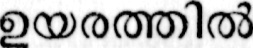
ഉയരത്തില്‍
